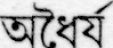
অধৈর্য
